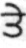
ਤੇ
